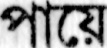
পায়ে
